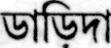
ডাড়িদা
